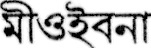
মীওইবনা
